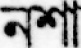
নশা
